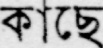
কাছে
